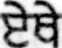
ਏਥੇ
